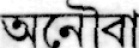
অনৌবা
